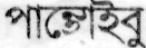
পান্থোইবু
